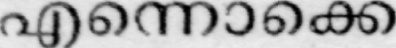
എന്നൊക്കെ
